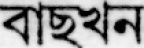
বাছখন
